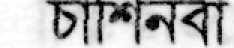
চাশিনবা
